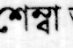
শেম্বা
